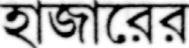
হাজারের
